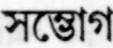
সম্ভোগ
